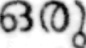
ഒരു
